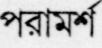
পরামর্শ
